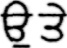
ਉਤੇ
